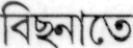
বিছনাতে
